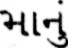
માનું
